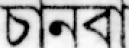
চানবা
